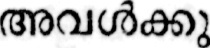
അവള്‍ക്കു
